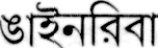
ঙাইনরিবা
